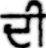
ਦੀ
